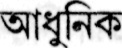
আধুনিক
